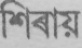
শিৰায়
